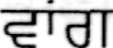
ਵਾਂਗ
